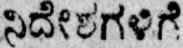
ನಿದೇಶಗಳಿಗೆ
